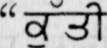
''ਕੁੱਤੀ
